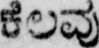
ಕೆಲವು
